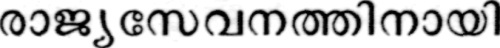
രാജ്യസേവനത്തിനായി
